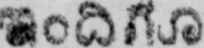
ಇಂದಿಗೂ
